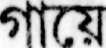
গায়ে
